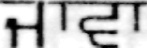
ਜਾਵਾਂ
